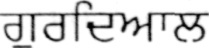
ਗੁਰਦਿਆਲ
